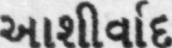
આશીર્વાદ
